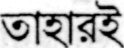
তাহারই
